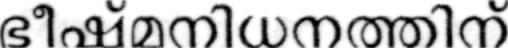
ഭീഷ്മനിധനത്തിന്
